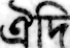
ঐদি
